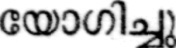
യോഗിച്ചു
